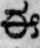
ಈ
